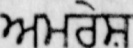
ਅਮਰੇਸ਼
